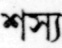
শস্য
